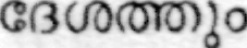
ദേശത്തും
